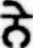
ਨੇ
